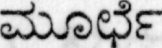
ಮೂರ್ಛೆ
